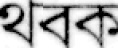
থবক
